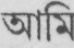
আমি
